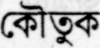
কৌতুক
